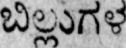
ಬಿಲ್ಲುಗಳ
